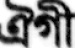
ঐগী
